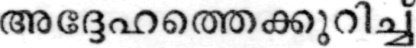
അദ്ദേഹത്തെക്കുറിച്ച്
